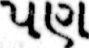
પણ
